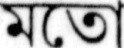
মতো
